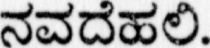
ನವದೆಹಲಿ.
